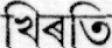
খিৰতি
